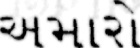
અમારો
